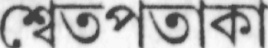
শ্বেতপতাকা
